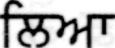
ਲਿਆ
